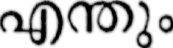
എന്തും
